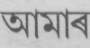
আমাৰ
